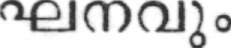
ഘനവും
